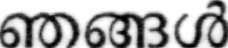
ഞങ്ങള്‍
